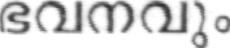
ഭവനവും
